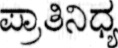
ಪ್ರಾತಿನಿಧ್ಯ
